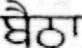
ਬੈਠਾ
